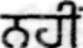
ਨਹੀਂ
